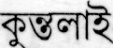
কুন্তলাই
